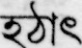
হঠাৎ
